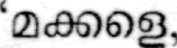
‘മക്കളെ,
